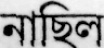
নাছিল
